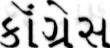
કૉગ્રેસ
